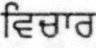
ਵਿਚਾਾਰ
